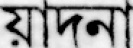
য়াদনা
